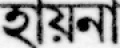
হায়না
